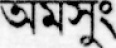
অমসুং
